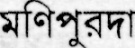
মণিপুরদা
